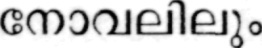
നോവലിലും
